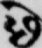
છે
